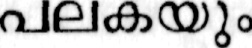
പലകയും
